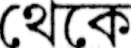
থেকে
